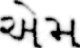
એમ
